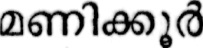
മണിക്കൂര്‍
